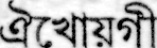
ঐখোয়গী
